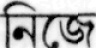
নিজে
